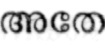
അതേ
